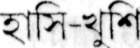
হাসি-খুশি
